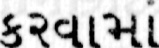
કરવામાં
